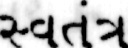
સ્વતંત્ર
